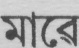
মাৱে
